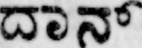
ದಾನ್
